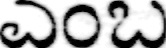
ಎಂಬ
